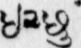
ઈચ્છું
